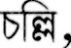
চল্লি,
